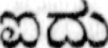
ಐದು
